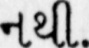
નથી.
